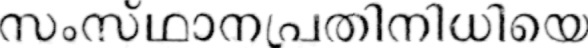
സംസ്ഥാനപ്രതിനിധിയെ
